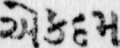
એકદમ
